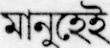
মানুহেই
